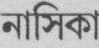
নাসিকা
